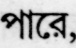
পারে,
